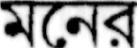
মনের
